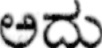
ಅದು
